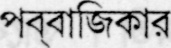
পব্বাজিকার
